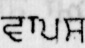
ਵਾਪਸ
